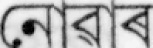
নোৱাৰ
